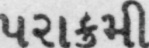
પરાક્રમી
